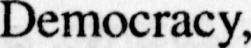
Democracy,
